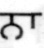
ਨਾ
